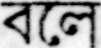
বলে
